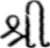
શ્રી
